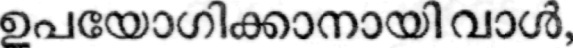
ഉപയോഗിക്കാനായിവാള്‍,
